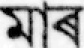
মাৰ
